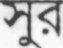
সুর
